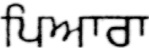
ਪਿਆਰਾ
